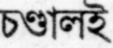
চণ্ডালই
